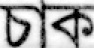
চাক
